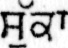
ਸੁੱਕਾ
